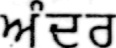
ਅੰਦਰ
